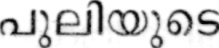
പുലിയുടെ
